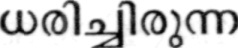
ധരിച്ചിരുന്ന
